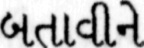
બતાવીને
